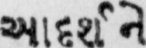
આદર્શને
